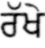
ਰੱਖੇ
